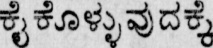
ಕೈಕೊಳ್ಳುವುದಕ್ಕೆ
